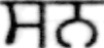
ਸਨ
